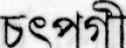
চৎপগী
